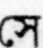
সে
